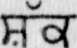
ਸ਼ੱਕ
